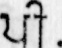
ਪੀ.
